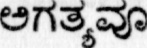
ಅಗತ್ಯವೂ
